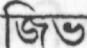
জিভ
